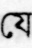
যে
